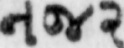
નજર
